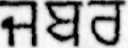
ਜਬਰ
